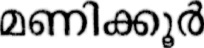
മണിക്കൂര്‍
